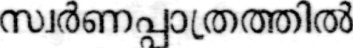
സ്വര്‍ണപ്പാത്രത്തില്‍
